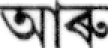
আৰু
